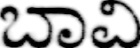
ಬಾವಿ
